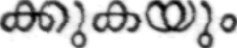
ക്കുകയും
